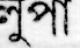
লুপা
